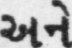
અને
